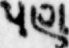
પણ
